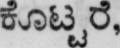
ಕೊಟ್ಟರೆ,
